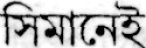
সিমানেই
